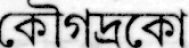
কৌগদ্রকো
